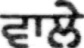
ਵਾਲੇ
